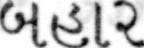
બહાર
